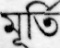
মূর্তি
